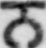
ਨ
